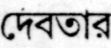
দেবতার
